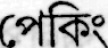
পেকিং
